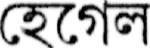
হেগেল
